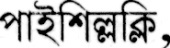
পাইশিল্লক্লি,
